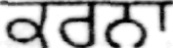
ਕਰਨਾ
